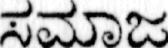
ಸಮಾಜ
